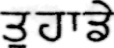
ਤੁਹਾਡੇ
